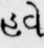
હવે
